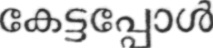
കേട്ടപ്പോള്‍
